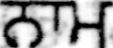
ਨਾਮ
